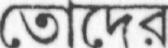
তোদের
